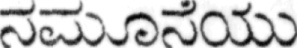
ನಮೂನೆಯು
